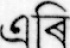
এৰি
